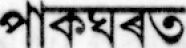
পাকঘৰত
